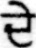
ਦੇ
